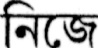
নিজে
